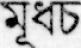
মূধচ
